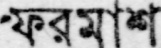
ফরমাশ
